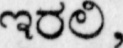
ಇರಲಿ,
